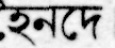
হৈনদে
